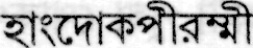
হাংদোকপীরম্মী
